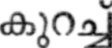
കുറച്ച്
